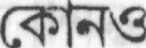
কোনও
